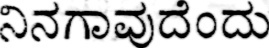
ನಿನಗಾವುದೆಂದು
